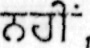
ਨਹੀਂ,
